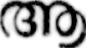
ആ
